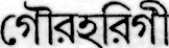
গৌরহরিগী
